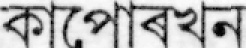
কাপোৰখন
